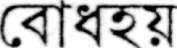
বোধহয়
